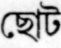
ছোট
